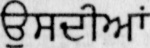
ਉਸਦੀਆਂ
